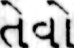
તેવો
